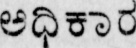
ಅಧಿಕಾರ
